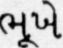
ભૂખે
